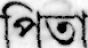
পিতা
